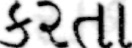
કરતા
